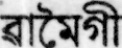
ৱামৈগী
